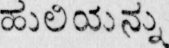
ಹುಲಿಯನ್ನು
